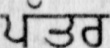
ਪੱਤਰ
